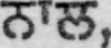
ਨਾਲ,
